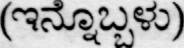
(ಇನ್ನೊಬ್ಬಳು)
